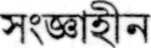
সংজ্ঞাহীন
